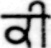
ਕੀ
